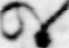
જ
